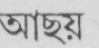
আছয়
